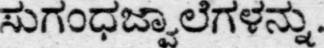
ಸುಗಂಧಜ್ವಾಲೆಗಳನ್ನು.
